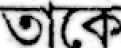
তাকে
